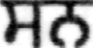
ਸਨ
